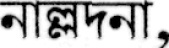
নাল্লদনা,
